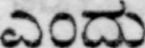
ಎಂದು
